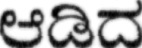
ಆಡಿದ
